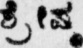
ಶ್ರೇಷ್ಠ
